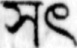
সৎ
